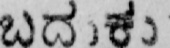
ಬದುಕು
